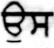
ਉਸ
